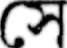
সে
